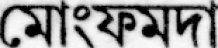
মোংফমদা
